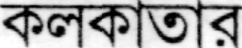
কলকাতার
